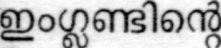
ഇംഗ്ലണ്ടിന്റെ
